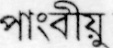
পাংবীয়ু
